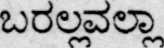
ಬರಲ್ಲವಲ್ಲಾ
